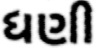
ઘણી
